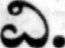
ವಿ.
